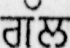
ਗੱਲ
